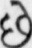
છે
